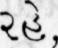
રહે,
